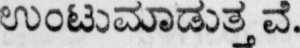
ಉಂಟುಮಾಡುತ್ತವೆ.
